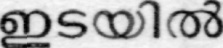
ഇടയില്‍
